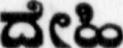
ದೇಹಿ
